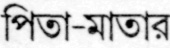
পিতা-মাতার
